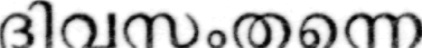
ദിവസംതന്നെ
